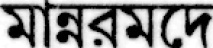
মান্নরমদে
